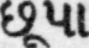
છૂપા
